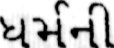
ધર્મની
